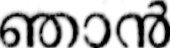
ഞാന്‍
